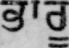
ਭਾਰੂ
